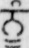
ਨੂੰ
